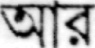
আর
